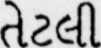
તેટલી
